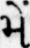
મેં
